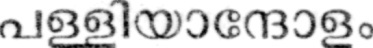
പള്ളിയാന്ദോളം
